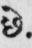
છે.
